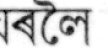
ঘৰলৈ
